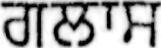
ਗਲਾਸ
